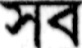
সব
